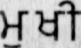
ਮੁਖੀ
